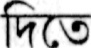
দিতে
